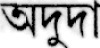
অদুদা
